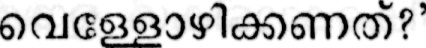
വെള്ളോഴിക്കണത്?’
